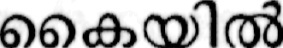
കൈയില്‍
